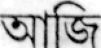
আজি
